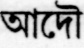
আদৌ
